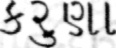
કરુણા
